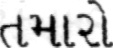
તમારો
